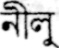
নীলু
